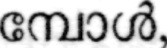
മ്പോള്‍,
